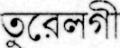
তুরেলগী
